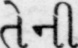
તેની
